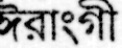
ঈরাংগী
